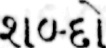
શબ્દો
